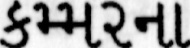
કમ્મરના
